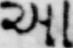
આ
